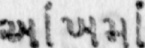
આંખમાં
